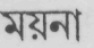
ময়না
